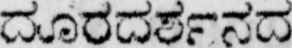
ದೂರದರ್ಶನದ
